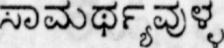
ಸಾಮರ್ಥ್ಯವುಳ್ಳ
